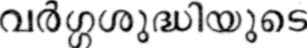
വര്‍ഗ്ഗശുദ്ധിയുടെ
